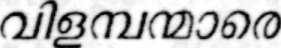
വിളമ്പന്മാരെ
